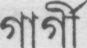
গার্গী
